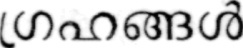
ഗ്രഹങ്ങള്‍
